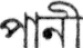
পানী
